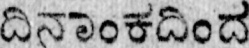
ದಿನಾಂಕದಿಂದ
